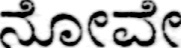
ನೋವೇ
